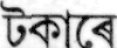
টকাৰে
